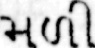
મળી
